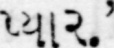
પ્યાર.'
